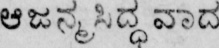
ಆಜನ್ಮಸಿದ್ಧವಾದ
